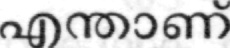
എന്താണ്
